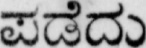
ಪಡೆದು
